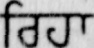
ਰਿਹਾ
